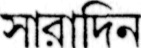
সারাদিন
